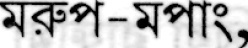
মরুপ-মপাং,
